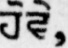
ਹੋਵੇ,
